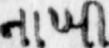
નાખી
